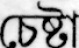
চেষ্টা
